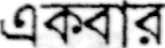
একবার
